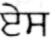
ਏਸ
